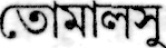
তোমালসু
